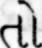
તો
